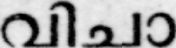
വിചാ
